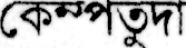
কেম্পতুদা
